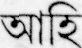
আহি
